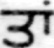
ਤਾਂ
